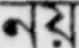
নয়
